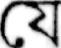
যে
